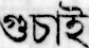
গুচাই
